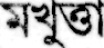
মখুত্তা
